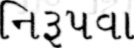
નિરૂપવા
